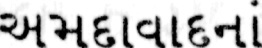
અમદાવાદનાં
